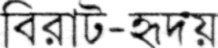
বিরাট-হৃদয়
